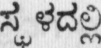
ಸ್ಥಳದಲ್ಲಿ
